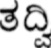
ತದ್ವಿ
